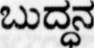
ಬುದ್ಧನ
